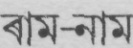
ৰাম-নাম
